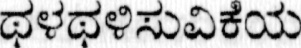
ಥಳಥಳಿಸುವಿಕೆಯ
